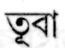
তূবা
